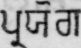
ਪ੍ਰਯੋਗ
